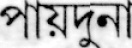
পায়দুনা
